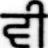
ਵੀ
